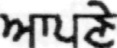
ਆਪਣੇ
